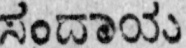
ಸಂದಾಯ
